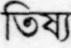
তিষ্য
